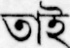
তাই
